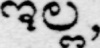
ಇಲ್ಲ,
